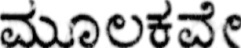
ಮೂಲಕವೇ
